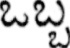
ಒಬ್ಬ
